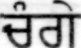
ਚੰਗੇ
